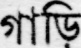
গাড়ি
